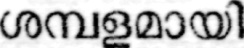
ശമ്പളമായി
